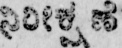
ನಿರೀಕ್ಷಣೆ
